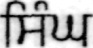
ਸਿੰਘ
